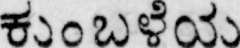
ಕುಂಬಳೆಯ
